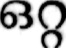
ഒറ്റ
